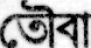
তৌবা
